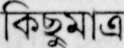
কিছুমাত্র
